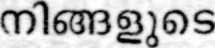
നിങ്ങളുടെ
